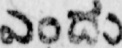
ಎಂದು
